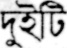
দুইটি
